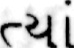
ત્યાં
